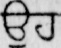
ਉਹ
